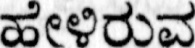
ಹೇಳಿರುವ
